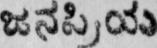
ಜನಪ್ರಿಯ
